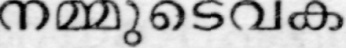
നമ്മുടെവക
